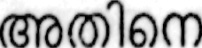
അതിനെ
